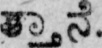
ತ್ತಾನೆ.
